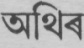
অথিৰ
